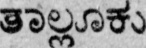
ತಾಲ್ಲೂಕು
